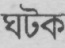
ঘটক
